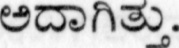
ಅದಾಗಿತ್ತು.
